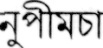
নুপীমচা
